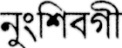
নুংশিবগী
